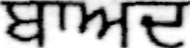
ਬਾਅਦ
